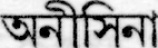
অনীসিনা
